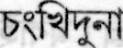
চংখিদুনা
